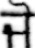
ਜੋ
